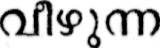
വീഴുന്ന
